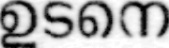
ഉടനെ
